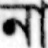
না
